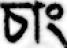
চাং
